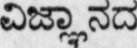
ವಿಜ್ಞಾನದ
